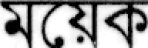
ময়েক
